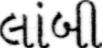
લાંબી
